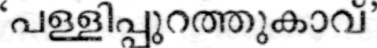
‘പള്ളിപ്പുറത്തുകാവ്’
